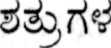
ಶತ್ರುಗಳ
